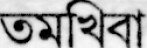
তমখিবা
